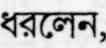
ধরলেন,
